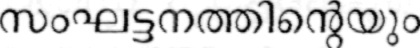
സംഘട്ടനത്തിന്റെയും
